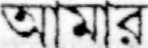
আমার
